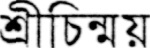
শ্রীচিন্ময়
